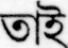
তাই
